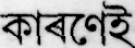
কাৰণেই
